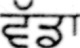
ਵੱਡਾ
